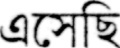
এসেছি
